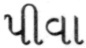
પીવા
